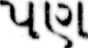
પણ
